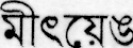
মীৎয়েঙ
